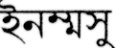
ইনম্মসু
